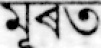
মূৰত
